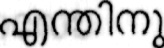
എന്തിനു
